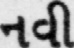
નવી
